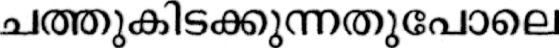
ചത്തുകിടക്കുന്നതുപോലെ
